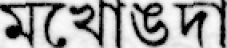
মখোঙদা
